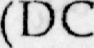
(DC
